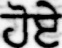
ਹੋਏ
